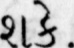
શકે.
